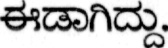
ಈಡಾಗಿದ್ದು.
